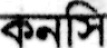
কনসি
